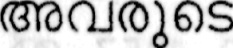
അവരുടെ
